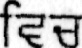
ਵਿਚ
